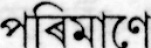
পৰিমাণে
